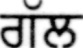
ਗੱਲ
